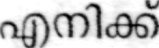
എനിക്ക്
